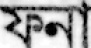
ফনা
